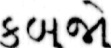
કબજો
